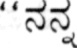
"ನನ್ನ
